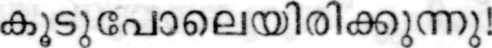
കൂടുപോലെയിരിക്കുന്നു!
